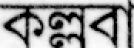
কল্লবা
